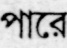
পারে
